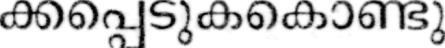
ക്കപ്പെടുകകൊണ്ടു
